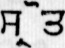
ਸ੍ਰੋਤ
